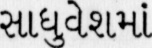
સાધુવેશમાં
